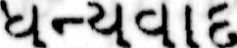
ધન્યવાદ
